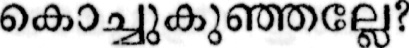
കൊച്ചുകുഞ്ഞല്ലേ?
